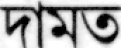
দামত
